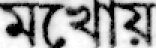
মখোয়
